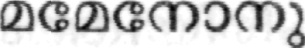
മമേനോനു
